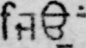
ਜਿਉਂ
